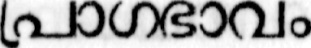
പ്രാഗഭാവം
